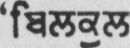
'ਬਿਲਕੁਲ
